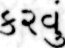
કરવું
